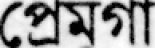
প্রেমগা
